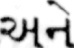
અને
